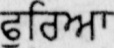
ਫੁਰਿਆ
